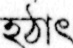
হঠাৎ
